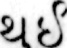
થઈ
